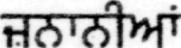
ਜ਼ਨਾਨੀਆਂ
